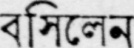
বসিলেন
